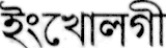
ইংখোলগী
